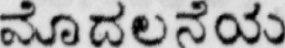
ಮೊದಲನೆಯ
